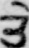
ਤੇ
